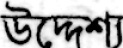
উদ্দেশ্য
